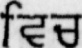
ਵਿਚ
